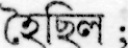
হৈছিল;
